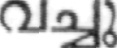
വച്ചു
